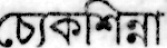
চ্যেকশিন্না
